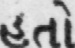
હતો
